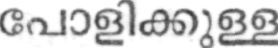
പോളിക്കുള്ള
